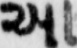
આ
